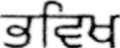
ਭਵਿਖ
